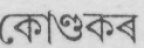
কোণ্ডকৰ
